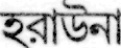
হরাউনা
